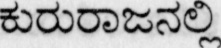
ಕುರುರಾಜನಲ್ಲಿ
